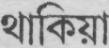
থাকিয়া
